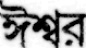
ঈশ্বর
